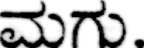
ಮಗು.
